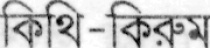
কিথি-কিরুম
